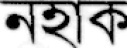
নহাক
